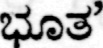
ಭೂತ’
